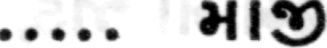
......માજી
